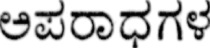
ಅಪರಾಧಗಳ
